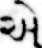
એ
